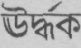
ঊৰ্দ্ধক
